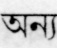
অন্য
